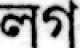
লগ
